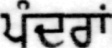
ਪੰਦਰਾਂ
